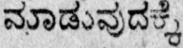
ಮಾಡುವುದಕ್ಕೆ
